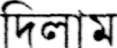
দিলাম
